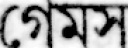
গেমস
